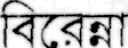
বিরেন্না
